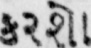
કરશો
